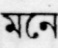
মনে
